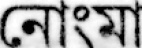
নোংমা
